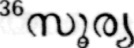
36സൂര്യ
